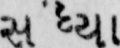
સંધ્યા
